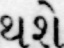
થશે
